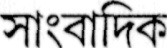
সাংবাদিক
